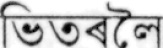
ভিতৰলৈ
